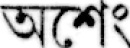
অশেং
